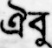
ঐবু
